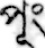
পূং
